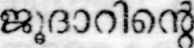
ജൂദാറിന്റെ
